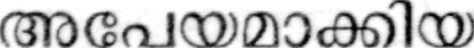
അപേയമാക്കിയ
